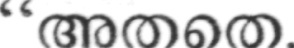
"അതതെ.
